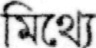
মিথ্যে
